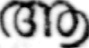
ആ
